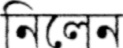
নিলেন
